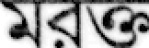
মরক্ত
